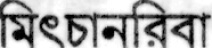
মিৎচানরিবা
